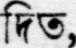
দিত,
